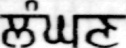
ਲੰਘਣ
